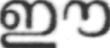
ഈ
